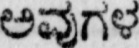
ಅವುಗಳ
